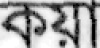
কয়া
